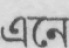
এনে
